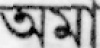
অমা
